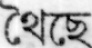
থৈছে
